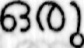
ഒരു
